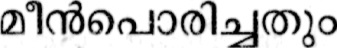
മീന്‍പൊരിച്ചതും
